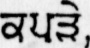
ਕਪੜੇ,
